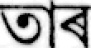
তাৰ
